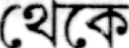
থেকে
